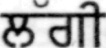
ਲੱਗੀ
